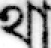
থা
